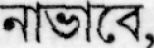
নাভাবে,
